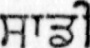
ਸਾਡੀ
